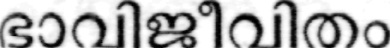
ഭാവിജീവിതം
